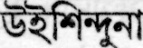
উইশিন্দুনা
